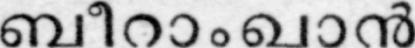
ബീറാംഖാന്‍
